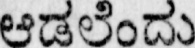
ಆಡಲೆಂದು
